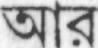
আর
